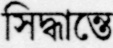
সিদ্ধান্তে
